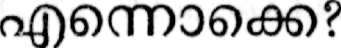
എന്നൊക്കെ?
